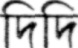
দিদি
